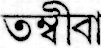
তম্বীবা
